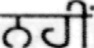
ਨਹੀਂ
